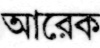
আরেক
